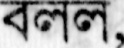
বলল,
